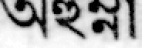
অহুম্না
